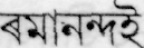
ৰমানন্দই
